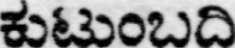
ಕುಟುಂಬದಿ
